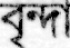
বৃন্দা
